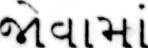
જોવામાં
